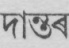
দান্তৰ
